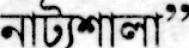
নাট্যশালা”
